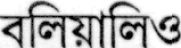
বলিয়ালিও
